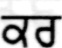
ਕਰ
